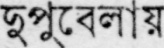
দুপুবেলায়
